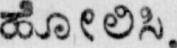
ಹೋಲಿಸಿ.
